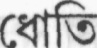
ধোতি
